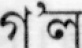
গ'ল
